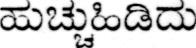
ಹುಚ್ಚುಹಿಡಿದು
